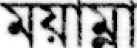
ময়াম্না
